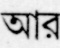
আর
